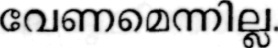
വേണമെന്നില്ല.
